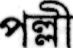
পল্লী
